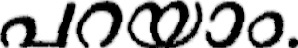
പറയാം.
